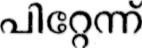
പിറ്റേന്ന്
